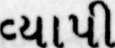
વ્યાપી
